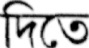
দিতে
